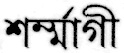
শর্ম্মাগী
